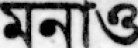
মনাও
